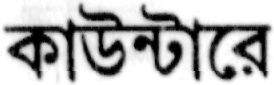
কাউন্টারে
